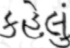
કહેલું
